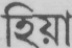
হিয়া
